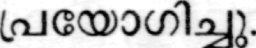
പ്രയോഗിച്ചു.
